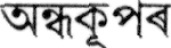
অন্ধকূপৰ
